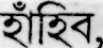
হাঁহিব,
